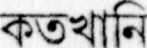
কতখানি
